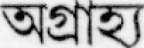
অগ্রাহ্য
